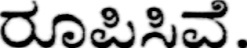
ರೂಪಿಸಿವೆ.
